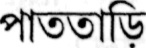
পাততাড়ি
